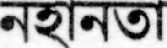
নহানতা
